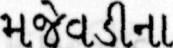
મજેવડીના
